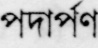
পদার্পণ
